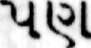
પણ
